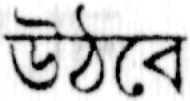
উঠবে
